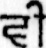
ਵੀ
